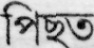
পিছত
